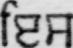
ਇਸ
